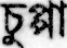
চুপ্পা
